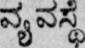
ವ್ಯವಸ್ಥೆ
